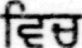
ਵਿਚ
